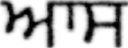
ਆਸ
